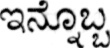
ಇನ್ನೊಬ್ಬ
